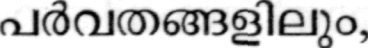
പര്‍വതങ്ങളിലും,
